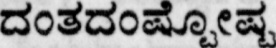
ದಂತದಂಷ್ಟೋಷ್ಟ
